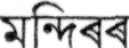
মন্দিৰৰ
